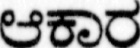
ಆಕಾರ
